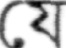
যে
